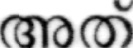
അത്
